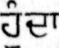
ਹੁੰਦਾ
